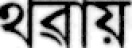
থৱায়
